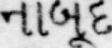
નાબૂદ
